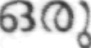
ഒരു
